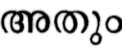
അതും
